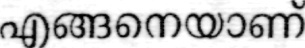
എങ്ങനെയാണ്
